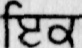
ਇਕ
